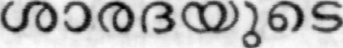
ശാരദയുടെ
